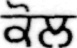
ਕੋਲ
